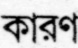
কারণ
